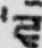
'ਵੋ
